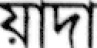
য়াদা
